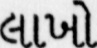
લાખો
